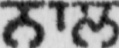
ਨਾਲ
